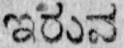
ಇರುವ
